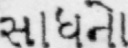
સાધનો
